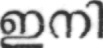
ഇനി
